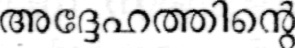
അദ്ദേഹത്തിന്റെ
